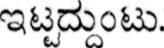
ಇಟ್ಟದ್ದುಂಟು.
